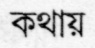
কথায়
